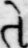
તે
